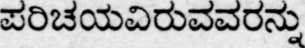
ಪರಿಚಯವಿರುವವರನ್ನು
